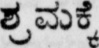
ಶ್ರಮಕ್ಕೆ
